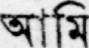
আমি
